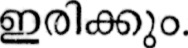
ഇരിക്കും.
